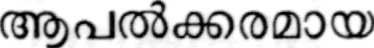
ആപല്‍ക്കരമായ
